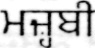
ਮਜ਼੍ਹਬੀ
